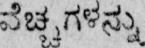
ವೆಚ್ಚಗಳನ್ನು
